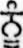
ਨੂੰ
